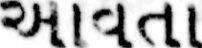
આવતા
